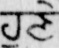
ਹੁਣੇ
